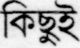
কিছুই
